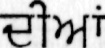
ਦੀਆਂ
